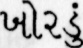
ખોરડું
